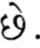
છે.
